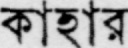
কাহার
